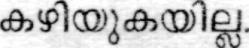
കഴിയുകയില്ല.
